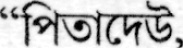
"পিতাদেউ,
